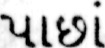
પાછાં
